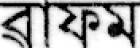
ৱাফম
